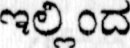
ಇಲ್ಲಿಂದ
